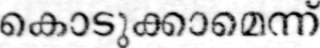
കൊടുക്കാമെന്ന്
